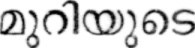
മുറിയുടെ
